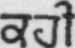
ਕਹੀ
